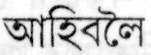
আহিবলৈ
